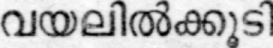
വയലില്‍ക്കൂടി
